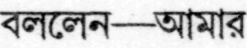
বললেন–আমার
